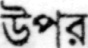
উপর
